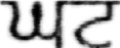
ਘਟ
